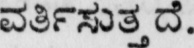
ವರ್ತಿಸುತ್ತದೆ.
